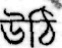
উঠি
